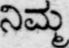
ನಿಮ್ಮ
